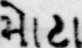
મોટા
